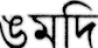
ঙমদি
